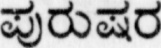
ಪುರುಷರ
